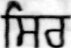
ਸਿਰ
